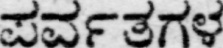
ಪರ್ವತಗಳ
